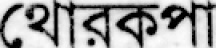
থোরকপা
